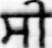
ਸੀ
